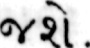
જશે.
